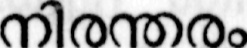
നിരന്തരം
